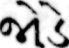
જોડે
